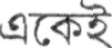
একেই
